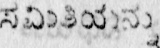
ಸಮಿತಿಯನ್ನು
